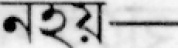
নহয়-
